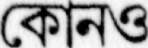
কোনও
